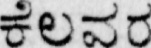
ಕೆಲವರ
